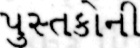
પુસ્તકોની
